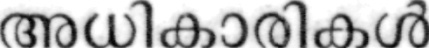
അധികാരികള്‍
